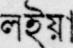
লইয়া
